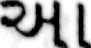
આ
